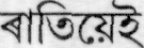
ৰাতিয়েই
